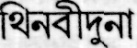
থিনবীদুনা
